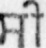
ਸੀ
